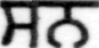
ਸਨ
